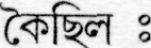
কৈছিলঃ
